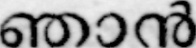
ഞാന്‍
